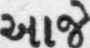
આજે
